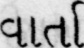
વાર્તા
